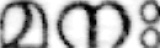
മനഃ
